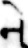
ને
